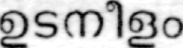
ഉടനീളം
